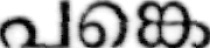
പങ്കെ
